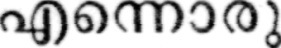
എന്നൊരു
